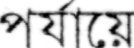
পর্যায়ে
